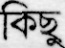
কিছু
